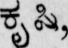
ಕೃಷಿ,
